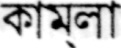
কাম্‌লা
